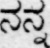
ನನ್ನ
